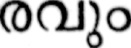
രവും
